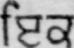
ਇਕ
